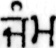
ਜੰਮ
